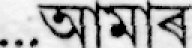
...আমাৰ
